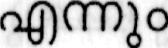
എന്നും
